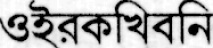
ওইরকখিবনি
